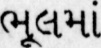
ભૂલમાં
